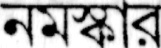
নমস্কার
